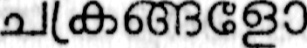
ചക്രങ്ങളോ
